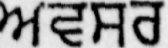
ਅਵਸਰ
